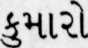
કુમારો
